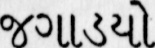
જગાડયો
